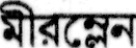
মীরম্লেন
